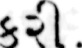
કરી.
